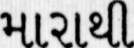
મારાથી
